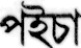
পইচা
